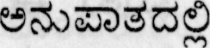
ಅನುಪಾತದಲ್ಲಿ
